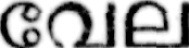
വേല
